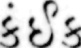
કંઈક
